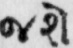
જશે
